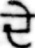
ਦੇ
